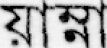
য়াম্না
